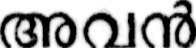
അവന്‍
